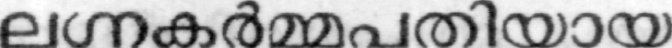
ലഗ്നകര്‍മ്മപതിയായ
